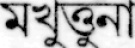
মখুত্তুনা
